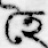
হৈ
